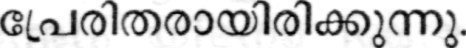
പ്രേരിതരായിരിക്കുന്നു.
